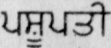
ਪਸ਼ੂਪਤੀ
